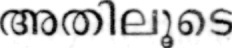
അതിലൂടെ
